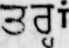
ਤਰ੍ਹਾਂ
